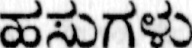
ಹಸುಗಳು
